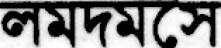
লমদমসে
